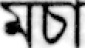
মচা
